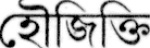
হৌজিক্তি
